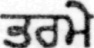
ਭਰਮੇ
